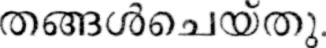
തങ്ങള്‍ചെയ്തു.
